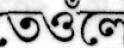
তেওঁলে
